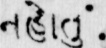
નહોતું.
